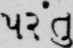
પરંતુ
